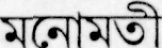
মনোমতী
